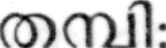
തമ്പി:
